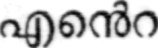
എന്റെ
